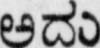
ಅದು
